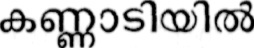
കണ്ണാടിയില്‍
